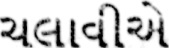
ચલાવીએ
